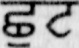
ਛੁਟ
